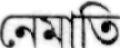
নেমাতি
